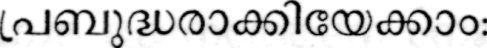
പ്രബുദ്ധരാക്കിയേക്കാം:
